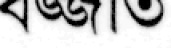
বজ্জাত
